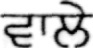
ਵਾਲੇ
